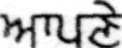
ਆਪਣੇ
